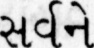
સર્વને
